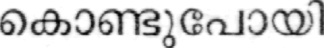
കൊണ്ടുപോയി
